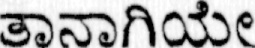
ತಾನಾಗಿಯೇ
